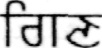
ਗਿਣ
